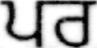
ਪਰ
